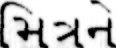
મિત્રને
